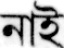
নাই
